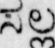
ಸಲ್ಲ
